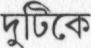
দুটিকে
